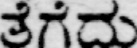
ತೆಗೆದು
